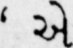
એ
